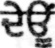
ਦੇਊਂ
